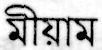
মীয়াম
